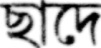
ছাদে
